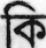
কি
